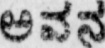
ಅವನ
